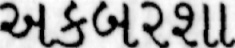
અકબરશા
